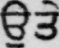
ਉਤੇ
